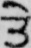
ਤੇ
